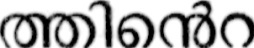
ത്തിന്റെ
